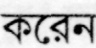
করেন
